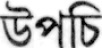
উপচি
